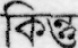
কিন্তু
